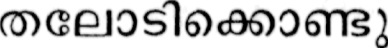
തലോടിക്കൊണ്ടു
